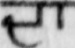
ਦਾ
